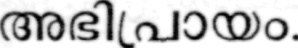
അഭിപ്രായം.
